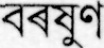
বৰষুণ
